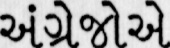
અંગ્રેજોએ
